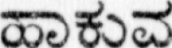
ಹಾಕುವ
